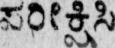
ಪರೀಕ್ಷಿಸಿ
